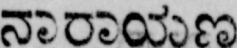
ನಾರಾಯಣ
